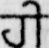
ਹੀ
